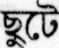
ছুটে
